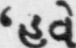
'હવે
